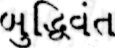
બુદ્ધિવંત
